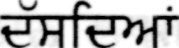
ਦੱਸਦਿਆਂ
